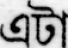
এটা
